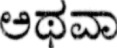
ಅಥವಾ
